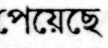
পেয়েছে
